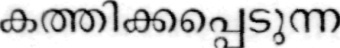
കത്തിക്കപ്പെടുന്ന
